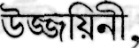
উজ্জয়িনী,
